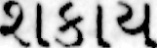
શકાય
